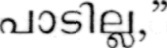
പാടില്ല,"
